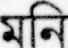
মনি
